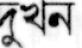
দুখন
